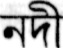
নদী
